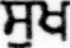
ਸੁਖ
